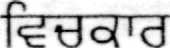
ਵਿਚਕਾਰ
